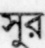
সুর
